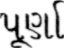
પૂર્ણા
